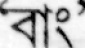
‘বাং’
